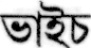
ভাইচ
